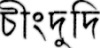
চীংদুদি
